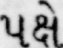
પક્ષે
